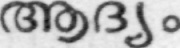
ആദ്യം
